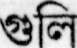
গুলি
